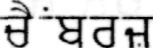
ਚੈਂਬਰਜ਼
